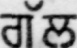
ਗੱਲ
